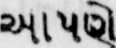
આપણે
